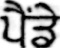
ਪੈਂਡੇ
